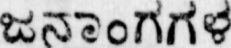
ಜನಾಂಗಗಳ
